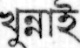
খুন্নাই
